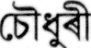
চৌধুৰী
